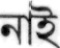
নাই
